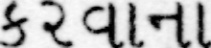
કરવાના
